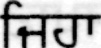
ਜਿਹਾ
